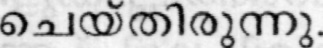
ചെയ്തിരുന്നു.
